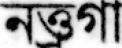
নত্ত্রগা
